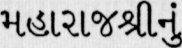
મહારાજશ્રીનું
